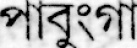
পাবুংগা
